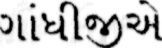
ગાંધીજીએ
